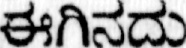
ಈಗಿನದು
